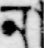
না
